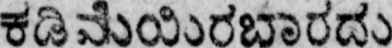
ಕಡಿಮೆಯಿರಬಾರದು
